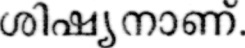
ശിഷ്യനാണ്.
